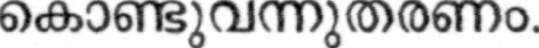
കൊണ്ടുവന്നുതരണം.
